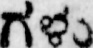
ಗಳು
